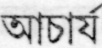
আচার্য
